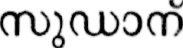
സുഡാന്
